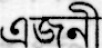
এজনী
